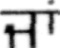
ਜਾਂ
